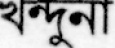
খন্দুনা
